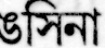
ঙসিনা
